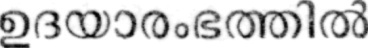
ഉദയാരംഭത്തില്‍
